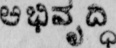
ಅಭಿವೃದ್ಧಿ
